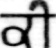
ਕੀ
